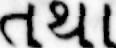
તથા
